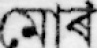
মোৰ
